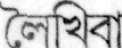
লৈখিবা
